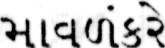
માવળંકરે
